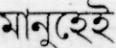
মানুহেই
